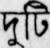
দুটি
